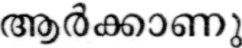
ആര്‍ക്കാണു
